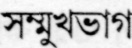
সম্মুখভাগ
